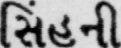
સિંહની
